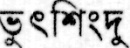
ভুৎশিংদু
